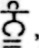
ਨੂੰ,
